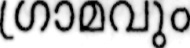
ഗ്രാമവും
